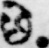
છે.
